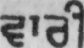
ਵਾਰੀ
